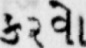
કરવો
